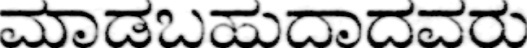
ಮಾಡಬಹುದಾದವರು
